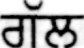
ਗੱਲ
